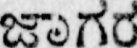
ಜಾಗರ
